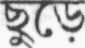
ছুড়ে
